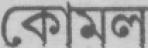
কোমল
